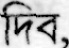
দিব,
